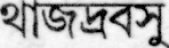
থজদ্রবসু
